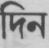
দিন
